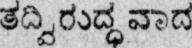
ತದ್ವಿರುದ್ಧವಾದ
